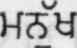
ਮਨੁੱਖ
